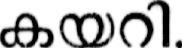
കയറി.
